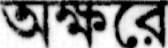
অক্ষরে
